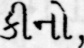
કીનો,
